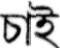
চাই
